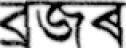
ব্রজৰ
